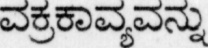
ವಕ್ರಕಾವ್ಯವನ್ನು
